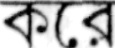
করে
